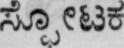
ಸ್ಫೋಟಕ
